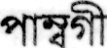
পাম্বগী
